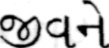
જીવને
